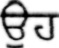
ਉਹ
